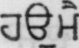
ਹਉਮੈ
